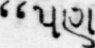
"પણ
